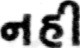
નહી
